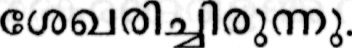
ശേഖരിച്ചിരുന്നു.
